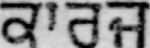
ਕਾਰਜ
